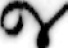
જ
